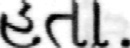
હતા.
